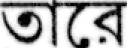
তারে
